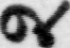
જ
